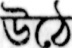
উঠে
